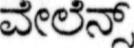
ವೇಲೆನ್ಸ್
